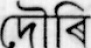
দৌৰি
